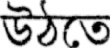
উঠতে
